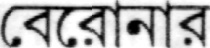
বেরোনার
